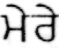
ਮੇਰੇ
